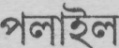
পলাইল
